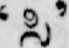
‘ಸಿ’
